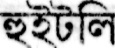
হুইটলি
